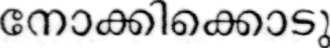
നോക്കിക്കൊടു
